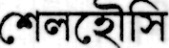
শেলহৌসি
